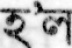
হ'ল
